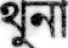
থুনা
